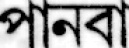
পানবা
